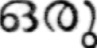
ഒരു
